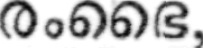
രംഭൈ,
